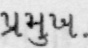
પ્રમુખ.
